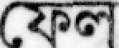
ফেল
